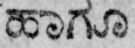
ಹಾಗೂ
